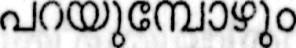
പറയുമ്പോഴും
